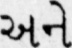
અને
